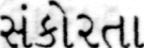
સંકોરતા
